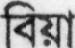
বিয়া
